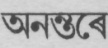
অনন্তৰে
